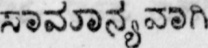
ಸಾಮಾನ್ಯವಾಗಿ
